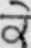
ਕੇ
